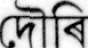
দৌৰি
